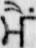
ਮੈਂ
